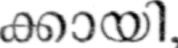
ക്കായി,
